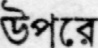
উপরে
